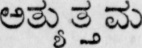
ಅತ್ಯುತ್ತಮ
